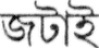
জটাই
